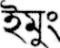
ইমুং
